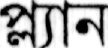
প্ল্যান
